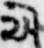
એ
